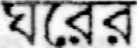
ঘরের
